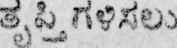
ತೃಪ್ತಿಗಳಿಸಲು
